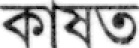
কাষত
